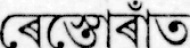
ৰেস্তোৰাঁত
